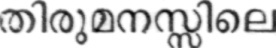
തിരുമനസ്സിലെ
